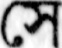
সে
